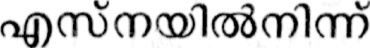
എസ്നയില്‍നിന്ന്
